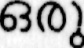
ഒരു
